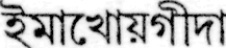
ইমাখোয়গীদা
